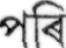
পৰি
